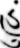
હુ
